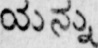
ಯನ್ನು
